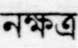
নক্ষত্র
